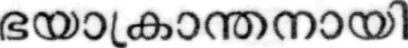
ഭയാക്രാന്തനായി
